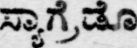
ಸ್ಯಾಗ್ರೆಡೊ
